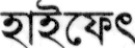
হাইফেৎ
